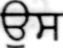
ਉਸ
